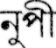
নুপী
